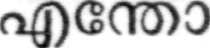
എന്തോ
